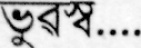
ভুৱস্ব....
